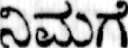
ನಿಮಗೆ
